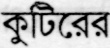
কুটিরের
